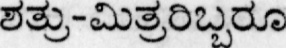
ಶತ್ರು-ಮಿತ್ರರಿಬ್ಬರೂ
